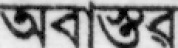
অবাস্তৱ
